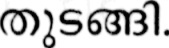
തുടങ്ങി.
